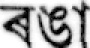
ৰঙা
